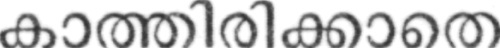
കാത്തിരിക്കാതെ
